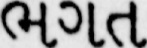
ભગત
